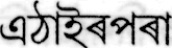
এঠাইৰপৰা
